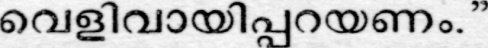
വെളിവായിപ്പറയണം.''
